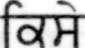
ਕਿਸੇ
